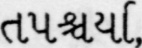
તરશ્ચર્યા,
